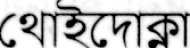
থোইদোক্না
